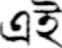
এই
